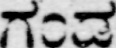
ಗಂಡ
